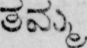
ತಮ್ಮ
